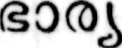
ഭാര്യ
